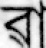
ৱা
